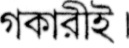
গকারীই।
